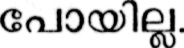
പോയില്ല.
